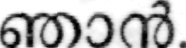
ഞാന്‍.
